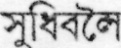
সুধিবলৈ
